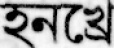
হনখ্রে
